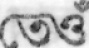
তেওঁ
